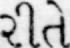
રીતે
